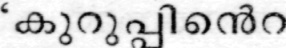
‘കുറുപ്പിന്റെ
